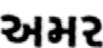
અમર
